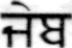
ਜੇਬ
